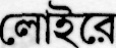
লোইরে
